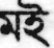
মই
